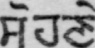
ਸੋਹਣੇ
